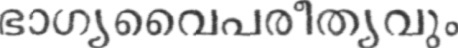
ഭാഗ്യവൈപരീത്യവും
